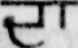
ਦਾ
